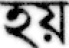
হয়
